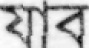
যাব
